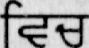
ਵਿਚ
